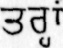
ਤਰ੍ਹਾਂ
